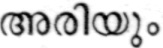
അരിയും
